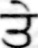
ਤੇ
